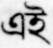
এই
